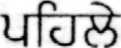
ਪਹਿਲੇ
